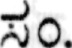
ಸಂ.
